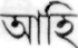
আহি
